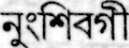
নুংশিবগী
